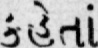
કહેતાં
